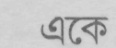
একে
